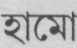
হামো
